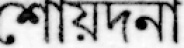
শোয়দনা
